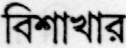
বিশাখার
